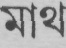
মাথ
